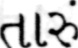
તારું
